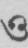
ও
